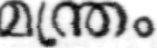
മന്ത്രം
